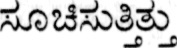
ಸೂಚಿಸುತ್ತಿತ್ತು
